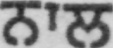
ਨਾਲ
